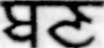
ਬਣ
